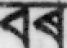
বৰ
